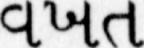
વખત
